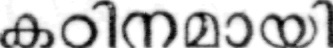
കഠിനമായി
